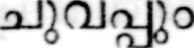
ചുവപ്പും
